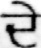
ਦੇ
